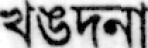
খঙদনা
